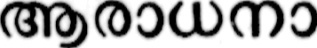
ആരാധനാ
